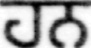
ਹਨ
